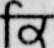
ਕਿ
